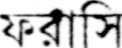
ফরাসি
